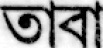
তাবা
